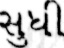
સુધી
